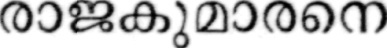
രാജകുമാരനെ
